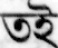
তই
